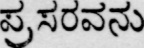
ಪ್ರಸರವನು
